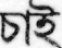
চাই
